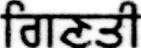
ਗਿਣਤੀ
